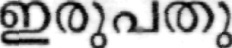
ഇരുപതു
